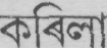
কৰিলা
